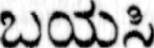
ಬಯಸಿ
